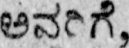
ಅವರಿಗೆ,
